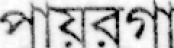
পায়রগা
